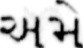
અમે
